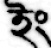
ইং
